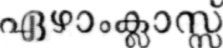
ഏഴാംക്ലാസ്സ്
